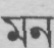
মন
